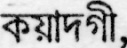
কয়াদগী,
